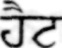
ਹੈਟ
